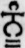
ਨੂੰ
